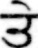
ਤੇ
